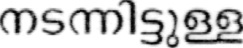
നടന്നിട്ടുള്ള
